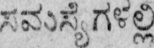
ಸಮಸ್ಯೆಗಳಲ್ಲಿ
